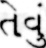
તેવું
